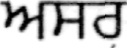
ਅਸਰ
